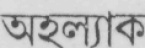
অহল্যাক
